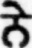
ਨੇ
